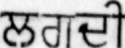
ਲਗਦੀ
